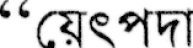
“য়েৎপদা
